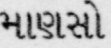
માણસો
